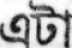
এটা
